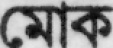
মোক
